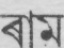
ৰাম
